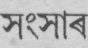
সংসাৰ
